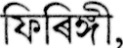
ফিৰিঙ্গী,
